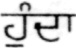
ਹੁੰਦਾ
